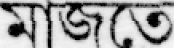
মাজতে
